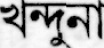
খন্দুনা
